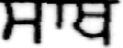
ਸਾਥ
